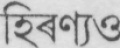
হিৰণ্যও
